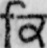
ਕਿ
